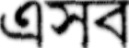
এসব
